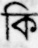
কি
